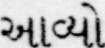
આવ્યો
